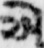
એ
